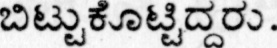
ಬಿಟ್ಟುಕೊಟ್ಟಿದ್ದರು.
